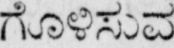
ಗೊಳಿಸುವ
